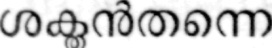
ശക്തന്‍തന്നെ
